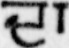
ਦਾ
